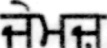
ਜੇਮਜ਼
